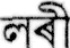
লৰী
